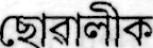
ছোৱালীক
